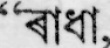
"ৰাধা,
